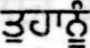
ਤੁਹਾਨੂੰ
